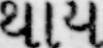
થાય
